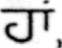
ਹਾਂ,
